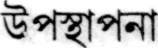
উপস্থাপনা
